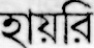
হায়রি
